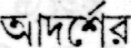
আদর্শের
